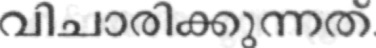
വിചാരിക്കുന്നത്.
